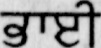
ਭਾਈ
